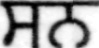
ਸਨ
